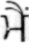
।ਮੈਂ
